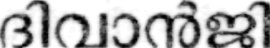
ദിവാന്‍ജി
